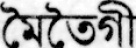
মৈতৈগী
